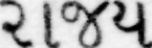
રાજ્ય
